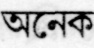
অনেক
